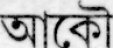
আকৌ
